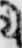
યે
